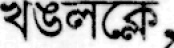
খঙলক্লে,
